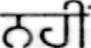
ਨਹੀਂ
